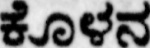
ಕೊಳನ
